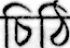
চিঠি
